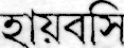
হায়বসি
